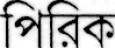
পিরিক
